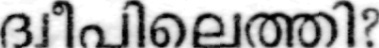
ദ്വീപിലെത്തി?
